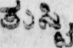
ತುಷ್ಟಿ
